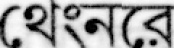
থেংনরে
